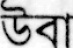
উবা
